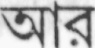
আর
